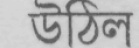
উঠিল
